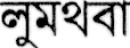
লুমথবা
